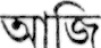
আজি
